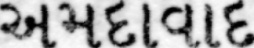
અમદાવાદ
